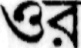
ওর
